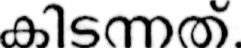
കിടന്നത്.
